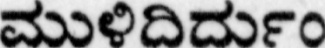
ಮುಳಿದಿರ್ದುಂ
